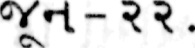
જૂન-૨૨.
